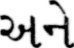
અને
